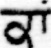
ਕਾਂ
